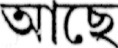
আছে
